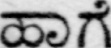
ಹಾಗೆ
